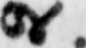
જ.
